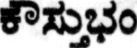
ಕೌಸ್ತುಭ೦
